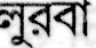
লুরবা
